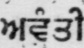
ਅਵੰਤੀ
